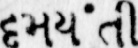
દમયંતી
